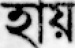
হায়
